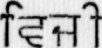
ਵਿਜੀ
